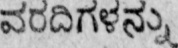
ವರದಿಗಳನ್ನು
